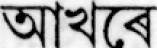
আখৰে
